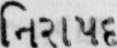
નિરાપદ
